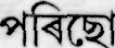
পৰিছো
